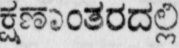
ಕ್ಷಣಾಂತರದಲ್ಲಿ
